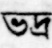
ভদ্র
